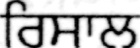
ਰਿਸਾਲ
